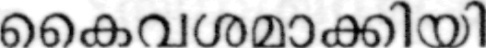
കൈവശമാക്കിയി
